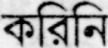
করিনি
